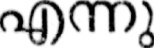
എന്നു
